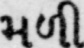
મળી
